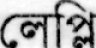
লেপ্লি
